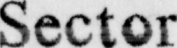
Sector
